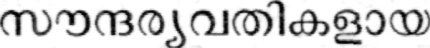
സൌന്ദര്യവതികളായ
